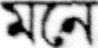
মনে
